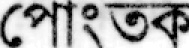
পোংতক
